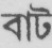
বাট
